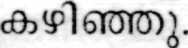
കഴിഞ്ഞു.
